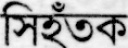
সিহঁতক
